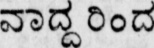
ವಾದ್ದರಿಂದ
